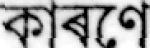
কাৰণে
